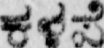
ಕಳಪೆ
